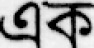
এক
